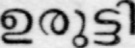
ഉരുട്ടി
